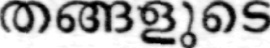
തങ്ങളുടെ
